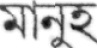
মানুহ
